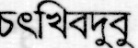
চৎখিবদুবু
